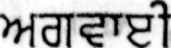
ਅਗਵਾਈ
